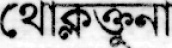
থোক্লক্তুনা
